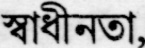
স্বাধীনতা,
